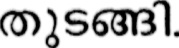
തുടങ്ങി.
